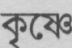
কৃষ্ণে
